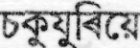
চকুযুৰিয়ে
